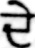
ਦੇ
